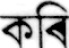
কৰি
